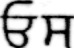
ਓਸ
